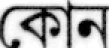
কোন
